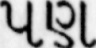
પણ
